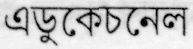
এডুকেচনেল
